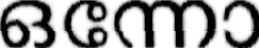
ഒന്നോ
